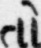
તો
